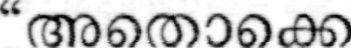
“അതൊക്കെ
